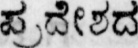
ಪ್ರದೇಶದ
